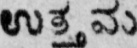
ಉತ್ತಮ
